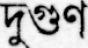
দুগুণ
